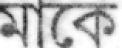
মাকে
